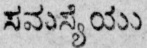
ಸಮಸ್ಯೆಯು
